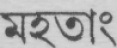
মহতাং
